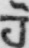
ਹੋ
